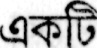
একটি
